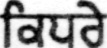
ਕਿਧਰੇ
